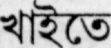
খাইতে
